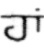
ਹਾਂ
